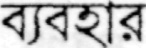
ব্যবহার
